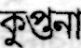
কুপ্তনা
